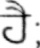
ਹੈ;
